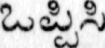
ಒಪ್ಪಿಸಿ
